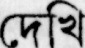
দেখি
